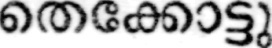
തെക്കോട്ടു
